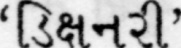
'ડિક્ષનરી'
